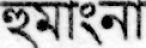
হুমাংনা
